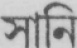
সানি
